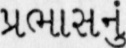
પ્રભાસનું
